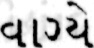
વાગ્યે
